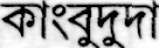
কাংবুদুদা
